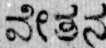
ವೇತನ
